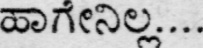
ಹಾಗೇನಿಲ್ಲ.....
